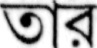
তার
